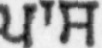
ਪਾਸ
